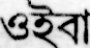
ওইবা
